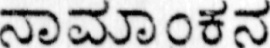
ನಾಮಾಂಕನ
